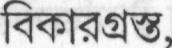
বিকারগ্রস্ত,
